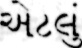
એટલું
